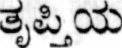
ತೃಪ್ತಿಯ
